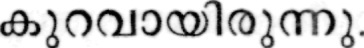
കുറവായിരുന്നു.
